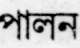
পালন
